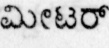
ಮೀಟರ್
